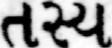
તસ્ય
